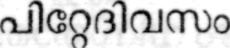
പിറ്റേദിവസം
